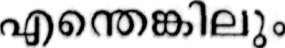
എന്തെങ്കിലും
